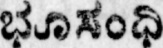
ಭೂಸಂಧಿ
